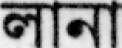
লানা
